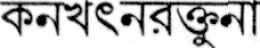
কনখৎনরক্তুনা
